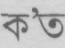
ক'ত
